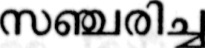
സഞ്ചരിച്ച
